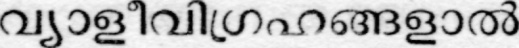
വ്യാളീവിഗ്രഹങ്ങളാല്‍
